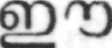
ഈ
